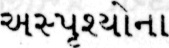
અસ્પૃશ્યોના
